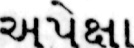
અપેક્ષા
